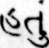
હતું
